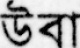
উবা
